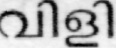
വിളി
